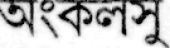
অংকলসু
